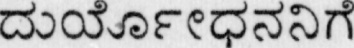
ದುರ್ಯೋಧನನಿಗೆ
